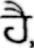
ਹੈ,
